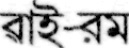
ৱাই-রম
